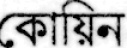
কোয়িন
